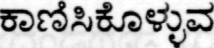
ಕಾಣಿಸಿಕೊಳ್ಳುವ
